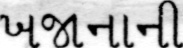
ખજાનાની
